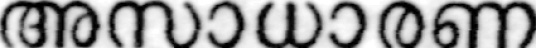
അസാധാരണ
